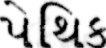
પેથિક
